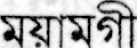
ময়ামগী
